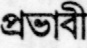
প্রভাবী
